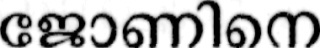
ജോണിനെ
